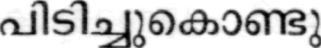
പിടിച്ചുകൊണ്ടു
